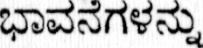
ಭಾವನೆಗಳನ್ನು
